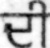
ਦੀ
